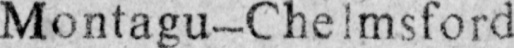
Montagu-Chelmsford
